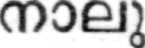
നാലു
